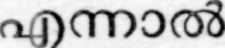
എന്നാല്‍
